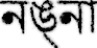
নঙ্না
